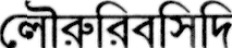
লৌরুরিবসিদি
